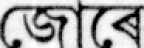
জোৰে
